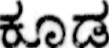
ಕೂಡ
